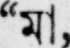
‘‘মা,
